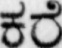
ಕರೆ
